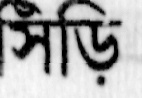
সিঁড়ি
